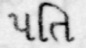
પતિ
